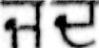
ਜਦ
